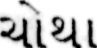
ચોથા
